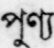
পুণ্য
